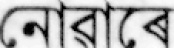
নোৱাৰে
